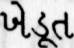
ખેડૂત
